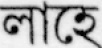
লাহে
